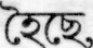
হৈছে,
